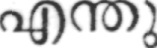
എന്തു
